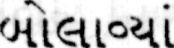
બોલાવ્યાં
